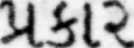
પ્રકાર
